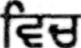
ਵਿਚ
